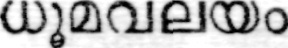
ധൂമവലയം
